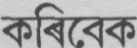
কৰিবেক
